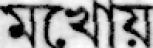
মখোয়
